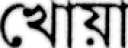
খোয়া
